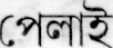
পেলাই
